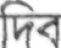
দিব
